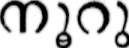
നൂറു
